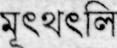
মূৎথৎলি
